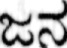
ಜನ
